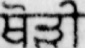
ਥੋੜੀ
